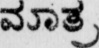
ಮಾತ್ರ
